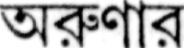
অরুণার
